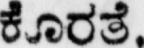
ಕೊರತೆ,
